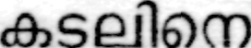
കടലിനെ
